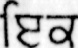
ਇਕ
